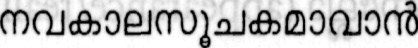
നവകാലസൂചകമാവാന്‍
